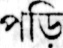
পড়ি
